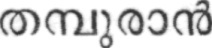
തമ്പുരാന്‍
